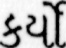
કર્યો
